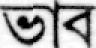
ভাব
